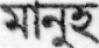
মানুহ
